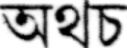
অথচ
